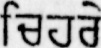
ਚਿਹਰੇ
